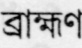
ব্রাহ্মণ
